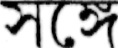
সঙ্গে
